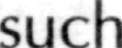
such
